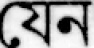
যেন
